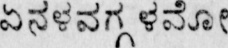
ಏನಳವಗ್ಗಳಮೋ
